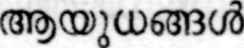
ആയുധങ്ങള്‍
